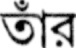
তাঁর
